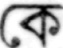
কে
